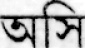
অসি
